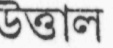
উত্তাল
